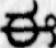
ಈ
